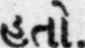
હતો.
